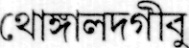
থোঙ্গালদগীবু
